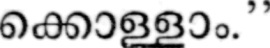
ക്കൊള്ളാം."
